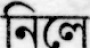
নিলে
